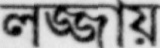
লজ্জায়
